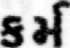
કર્મ
